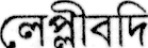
লেপ্লীবদি
